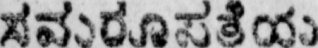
ಸಮರೂಪತೆಯ
